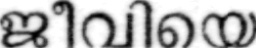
ജീവിയെ
